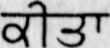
ਕੀਤਾ
